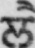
ਲੈ
